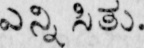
ಎನ್ನಿಸಿತು.
